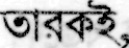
তারকই,
